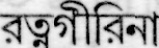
রত্নগীরিনা
